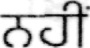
ਨਹੀਂ
